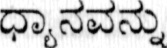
ಧ್ಯಾನವನ್ನು
